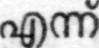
എന്ന്
